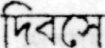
দিবসে
